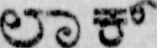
ಲಾಕ್
